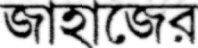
জাহাজের
